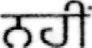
ਨਹੀਂ
